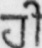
ਹੀ
